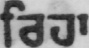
ਰਿਹਾ
